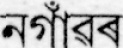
নগাঁৱৰ
